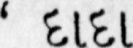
'દાદા
